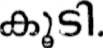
കൂടി.
